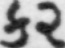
કર
